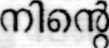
നിന്റെ
